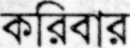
করিবার
